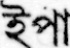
ইপা
